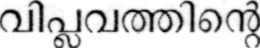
വിപ്ലവത്തിന്റെ
